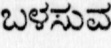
ಬಳಸುವ
